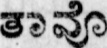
ತಾವೊ
